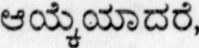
ಆಯ್ಕೆಯಾದರೆ,
